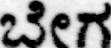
ಬೇಗ
